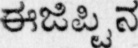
ಈಜಿಪ್ಟಿನ
